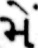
મેં
